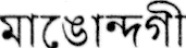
মাঙোন্দগী
